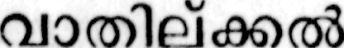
വാതില്ക്കല്‍
